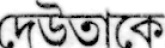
দেউতাকে
